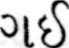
ગઈ
